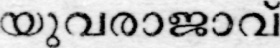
യുവരാജാവ്
